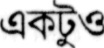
একটুও
